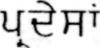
ਪ੍ਰਦੇਸਾਂ
